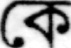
কে
